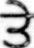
ਤੇ
